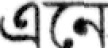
এনে
